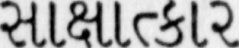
સાક્ષાત્કાર
